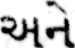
અને
